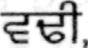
ਵਢੀ,
